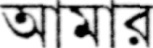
আমার
